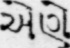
એણે
